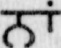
ਨਾਂ
